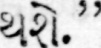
થશે."
